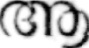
ആ
